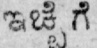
ಇಚ್ಛೆಗೆ
